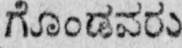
ಗೊಂಡವರು
